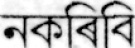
নকৰিবি
